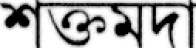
শক্তমদা
